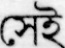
সেই
